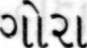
ગોરા
